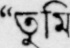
‘‘তুমি
